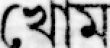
খোম
